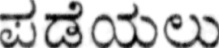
ಪಡೆಯಲು
